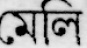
মেলি
